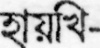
হায়খি-
